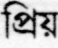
প্রিয়
